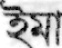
ইমা
